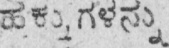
ಹಕ್ಕುಗಳನ್ನು
